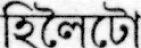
হিলৈটো
